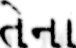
તેના
